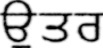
ਉਤਰ
